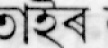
তাইৰ
